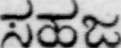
ಸಹಜ
